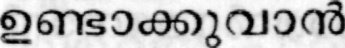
ഉണ്ടാക്കുവാന്‍
